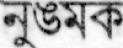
নুঙমক
